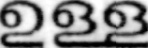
ഉള്ള
